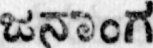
ಜನಾಂಗ
